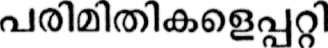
പരിമിതികളെപ്പറ്റി
